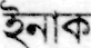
ইনাক
